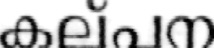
കല്പന
